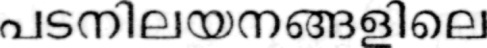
പടനിലയനങ്ങളിലെ
